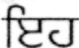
ਇਹ
